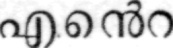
എന്റെ
